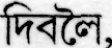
দিবলৈ,
